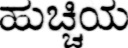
ಹುಚ್ಚಿಯ
